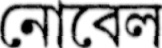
নোবেল
